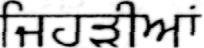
ਜਿਹੜੀਆਂ
